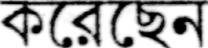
করেছেন
